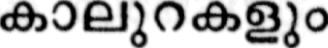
കാലുറകളും
